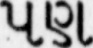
પણ
